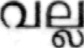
വല്ല
